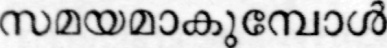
സമയമാകുമ്പോള്‍
